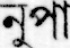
নুপা
